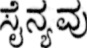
ಸೈನ್ಯವು
